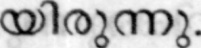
യിരുന്നു.
